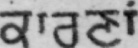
ਕਾਰਣਾਂ
